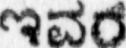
ಇವರ
